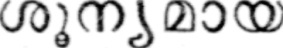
ശൂന്യമായ
